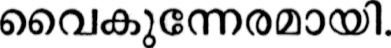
വൈകുന്നേരമായി.
